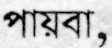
পায়বা,
